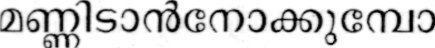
മണ്ണിടാന്‍നോക്കുമ്പോ
